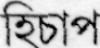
হিচাপ
